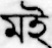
মই
